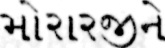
મોરારજીને
